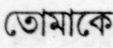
তোমাকে
